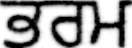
ਭਰਮ
